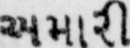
અમારી
